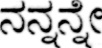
ನನ್ನನ್ನೇ
